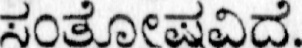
ಸಂತೋಷವಿದೆ.
